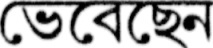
ভেবেছেন
